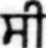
ਸੀ
